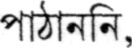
পাঠাননি,
